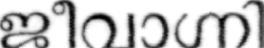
ജീവാഗ്നി
